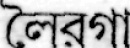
লৈরগা
